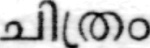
ചിത്രം
